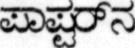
ಪಾಪ್ಟರ್‌ನ
